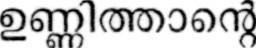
ഉണ്ണിത്താന്റെ
